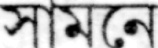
সামনে
